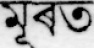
মূৰত
